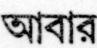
আবার
